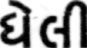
ધેલી
